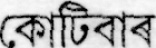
কোটিবাৰ
